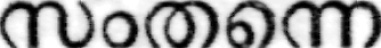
സംതന്നെ
